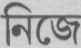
নিজে
